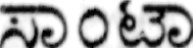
ಸಾಂಟಾ
